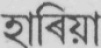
হাৰিয়া
